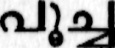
പൂച്ച
